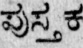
ಪುಸ್ತಕ
